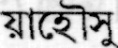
য়াহৌসু
